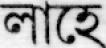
লাহে
